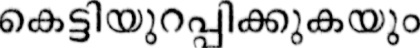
കെട്ടിയുറപ്പിക്കുകയും
